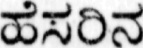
ಹೆಸರಿನ
